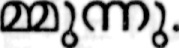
മ്മുന്നു.
